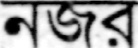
নজর
